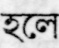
হলে
